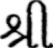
શ્રી
